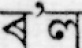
ৰ'ল
